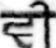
ਵੀ
